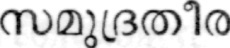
സമുദ്രതീര
